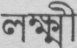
লক্ষ্মী
